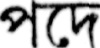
পদে
